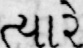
ત્યારે
